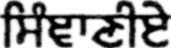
ਸਿੰਞਾਣੀਏ
